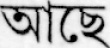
আছে
